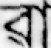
ৱা
